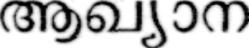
ആഖ്യാന
